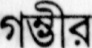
গম্ভীর
